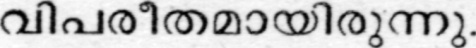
വിപരീതമായിരുന്നു.
